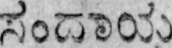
ಸಂದಾಯ
